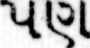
પણ
